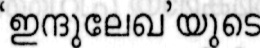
'ഇന്ദുലേഖ'യുടെ
